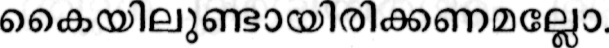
കൈയിലുണ്ടായിരിക്കണമല്ലോ.
